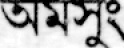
অমসুং
